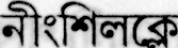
নীংশিলক্লে
